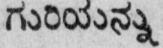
ಗುರಿಯನ್ನು
